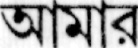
আমার
